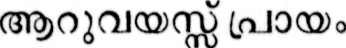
ആറുവയസ്സ്പ്രായം
